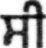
ਸੀ
